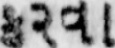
કરવા
